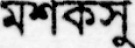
মশকসু
